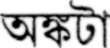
অঙ্কটা
